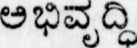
ಅಭಿವೃದ್ಧಿ
